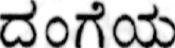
ದಂಗೆಯ
